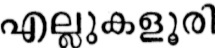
എല്ലുകളൂരി
